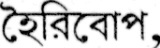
হৈরিবোপ,
